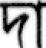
দা
